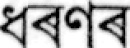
ধৰণৰ
